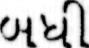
બધી
